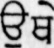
ਉਥੇ
